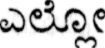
ಎಲ್ಲೋ
